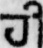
ਹੀ
